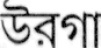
উরগা
